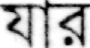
যার
